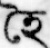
হৈ
